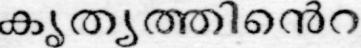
കൃത്യത്തിന്റെ
